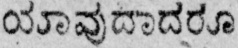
ಯಾವುದಾದರೂ
